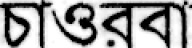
চাওরবা
